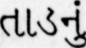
તાડનું
